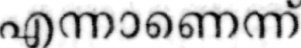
എന്നാണെന്ന്
